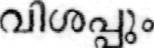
വിശപ്പും
